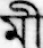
মী
